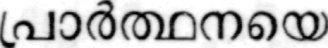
പ്രാര്‍ത്ഥനയെ
